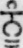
ਨੂੰ
